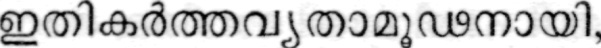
ഇതികര്‍ത്തവ്യതാമൂഢനായി,
